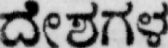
ದೇಶಗಳ
